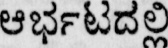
ಆರ್ಭಟದಲ್ಲಿ
